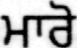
ਮਾਰੋ
